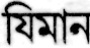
যিমান
